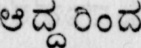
ಆದ್ದರಿಂದ
